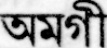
অমগী
